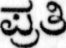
ಪ್ರತಿ
